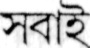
সবাই
